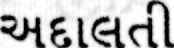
અદાલતી
